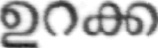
ഉറക്ക
